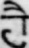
ਹੈ
